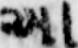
આ
